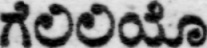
ಗೆಲಿಲಿಯೊ
